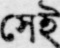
সেই
